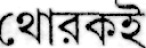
থোরকই
